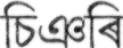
চিঞৰি
